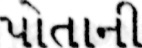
પોતાની
